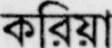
করিয়া
